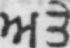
ਅਤੇ
